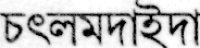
চৎলমদাইদা
